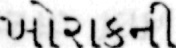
ખોરાકની
